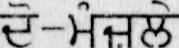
ਦੋ-ਮੰਜ਼ਲੇ
